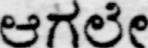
ಆಗಲೇ
